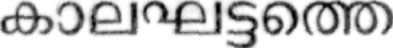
കാലഘട്ടത്തെ
